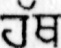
ਹੱਥ
